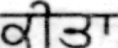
ਕੀਤਾ
